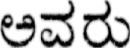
ಅವರು
